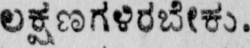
ಲಕ್ಷಣಗಳಿರಬೇಕು.
